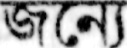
জন্যে
